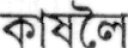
কাষলৈ
